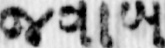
જવાબ
